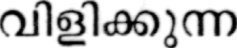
വിളിക്കുന്ന
